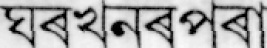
ঘৰখনৰপৰা
